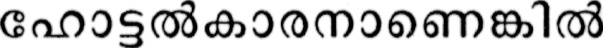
ഹോട്ടല്‍കാരനാണെങ്കില്‍
